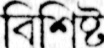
বিশিষ্ট
